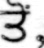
ਤੋਂ,
